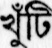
খুঁটি
